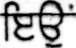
ਇਉਂ
